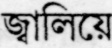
জ্বালিয়ে
